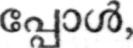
പ്പോള്‍,
